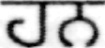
ਹਨ
